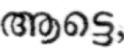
ആട്ടെ,
